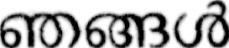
ഞങ്ങള്‍
